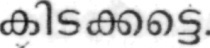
കിടക്കട്ടെ.
